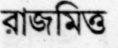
রাজমিত্ত
